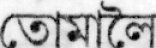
তোমালৈ
